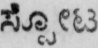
ಸ್ಪೋಟ
